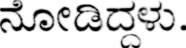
ನೋಡಿದ್ದಳು.
